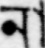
না
